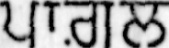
ਪਾਗ਼ਲ
